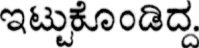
ಇಟ್ಟುಕೊಂಡಿದ್ದ.
